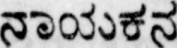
ನಾಯಕನ
